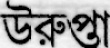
উরুপ্তা
